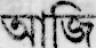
আজি
